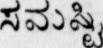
ಸಮಷ್ಟಿ
